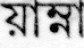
য়াম্না
